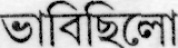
ভাবিছিলো
